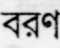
বরণ
